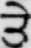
ਤੇ
